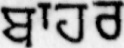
ਬਾਹਰ
